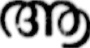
ആ
